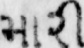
મારી
